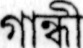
গান্ধী
